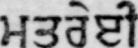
ਮਤਰੇਈ
